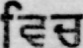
ਵਿਚ
